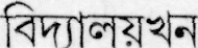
বিদ্যালয়খন
